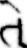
તે
